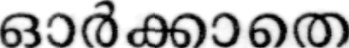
ഓര്‍ക്കാതെ
